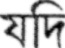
যদি
